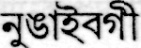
নুঙাইবগী
